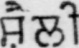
ਸ਼ੈਲੀ
